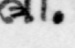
સ્ત્રી.
